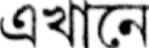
এখানে
